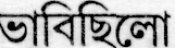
ভাবিছিলো
